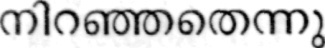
നിറഞ്ഞതെന്നു
